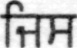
ਜਿਸ
